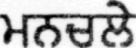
ਮਨਚਲੇ
